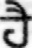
ਹੈ
